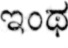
ಇಂಥ
